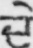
ਦੇ
